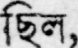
ছিল,
